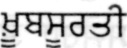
ਖ਼ੂਬਸੂਰਤੀ
